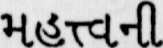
મહત્ત્વની
